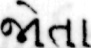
જોતા
